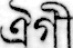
ঐগী
